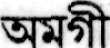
অমগী
